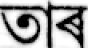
তাৰ
